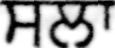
ਸਲਾ
